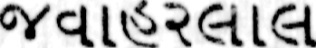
જવાહરલાલ
